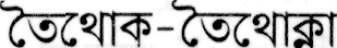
তৈথোক-তৈথোক্না
